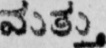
ಮತ್ತು
